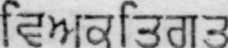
ਵਿਅਕਤਿਗਤ
